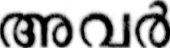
അവര്‍
